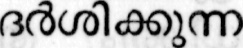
ദര്‍ശിക്കുന്ന
